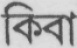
কিবা
